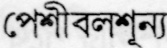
পেশীবলশূন্য
